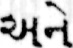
અને
